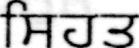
ਸਿਹਤ
